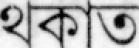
থকাত
